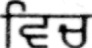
ਵਿਚ
